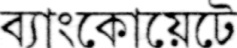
ব্যাংকোয়েটে
